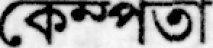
কেম্পতা
